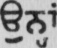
ਉਨ੍ਹਾਂ
